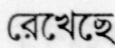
রেখেছে
